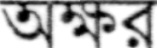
অক্ষর
